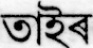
তাইৰ
